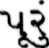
પૂરું
